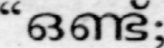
"ഒണ്ട്;
